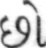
છો
